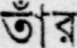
তাঁর
